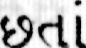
છતાં
